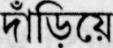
দাঁড়িয়ে
